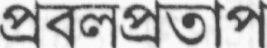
প্রবলপ্রতাপ
